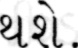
થશે.
